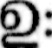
ഉ:
